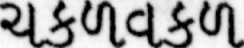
ચકળવકળ
